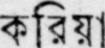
করিয়া
